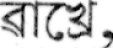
ৱাখ্রে,
